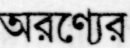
অরণ্যের
